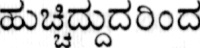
ಹುಚ್ಚಿದ್ದುದರಿಂದ
